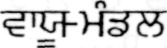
ਵਾਯੂ-ਮੰਡਲ
